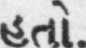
હતો.
